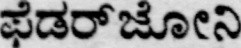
ಫೆಡರ್‌ಜೋನಿ
